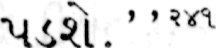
પડશે."૨૪૧
